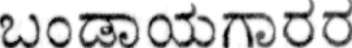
ಬಂಡಾಯಗಾರರ
